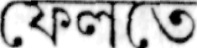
ফেলতে
